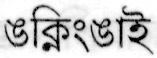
ঙক্নিংঙাই
